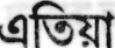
এতিয়া
